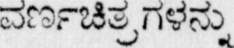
ವರ್ಣಚಿತ್ರಗಳನ್ನು
